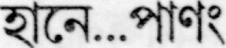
হানে...পাণং
